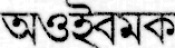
অওইবমক
